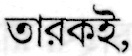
তারকই,
